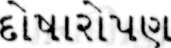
દોષારોપણ
